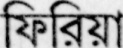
ফিরিয়া
